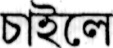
চাইলে
